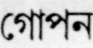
গোপন
